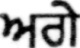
ਅਗੇ
